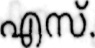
എസ്.
